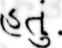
હતું.
